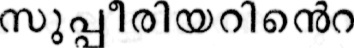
സുപ്പീരിയറിന്റെ
